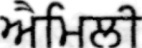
ਐਮਿਲੀ
